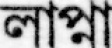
লাপ্না
